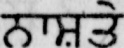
ਨਾਸ਼ਤੇ
